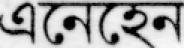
এনেহেন
